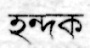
হন্দক
